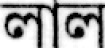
লাল
